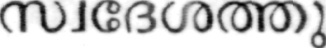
സ്വദേശത്തു
